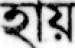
হায়
